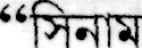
“সিনাম
